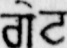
ਗੇਟ
